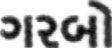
ગરબો
